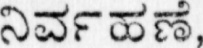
ನಿರ್ವಹಣೆ,
